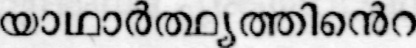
യാഥാര്‍ത്ഥ്യത്തിന്റെ
